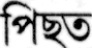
পিছত
